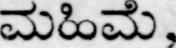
ಮಹಿಮೆ,
